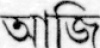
আজি
